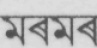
মৰমৰ
